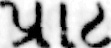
પ્રાટ
